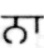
ਨਾ
